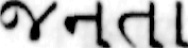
જનતા
